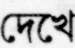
দেখে
